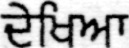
ਦੇਖਿਆ
